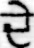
ਦੇ
